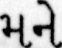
મને
